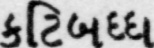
કટિબધ્ધ
